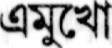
এমুখো
